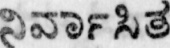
ನಿರ್ವಾಸಿತ
